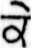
ਕੇ
